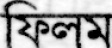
ফিলম
